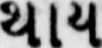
થાય
